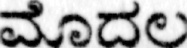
ಮೊದಲ
